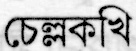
চেল্লকখি
